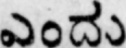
ಎಂದು
